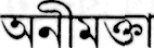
অনীমক্তা
